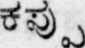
ಕಪ್ಪು
